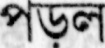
পড়ল
